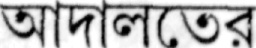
আদালতের
